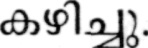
കഴിച്ചു.
